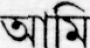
আমি
